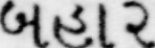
બહાર
